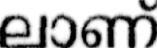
ലാണ്
